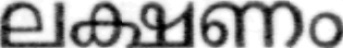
ലക്ഷണം
